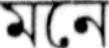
মনে
